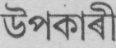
উপকাৰী
